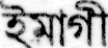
ইমাগী
